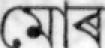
মোৰ
